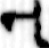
ન
